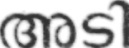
അടി
